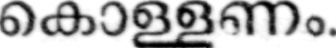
കൊള്ളണം.
